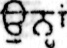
ਉਨ੍ਹਾਂ
